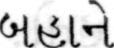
બહાને
